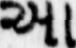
આ
